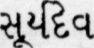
સૂર્યદેવ
